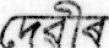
দেৱীৰ
